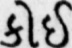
કોઈ
